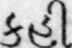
કહી
